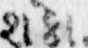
શકો.
